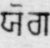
ਯੋਗ
